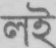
লই
